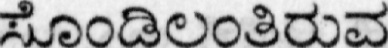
ಸೊಂಡಿಲಂತಿರುವ
